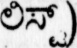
ಲಿಸ್ಟ್)
